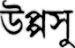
উপ্পসু
